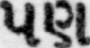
પણ
